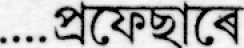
....প্রফেছাৰে
